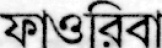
ফাওরিবা
